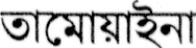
তামোয়াইনা
